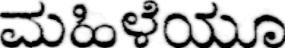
ಮಹಿಳೆಯೂ
